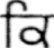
ਕਿ
